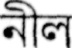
নীল
